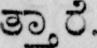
ತ್ತಾರೆ.
